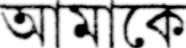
আমাকে
